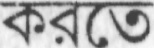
করতে
